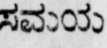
ಸಮಯ
